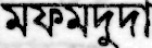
মফমদুদা
